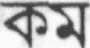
কম
